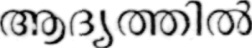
ആദ്യത്തില്‍
